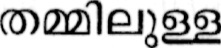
തമ്മിലുള്ള
